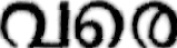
വരെ
